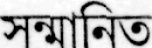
সন্মানিত
